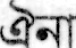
ঐনা
